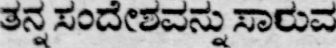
ತನ್ನಸಂದೇಶವನ್ನುಸಾರುವ
